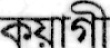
কয়াগী
